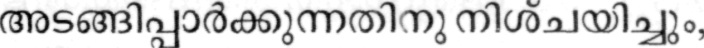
അടങ്ങിപ്പാര്‍ക്കുന്നതിനുനിശ്ചയിച്ചും,
